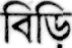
বিড়ি
